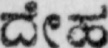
ದೇಹ
